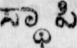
ಸ್ಥಾಪಿ
